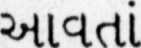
આવતાં
